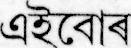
এইবোৰ
